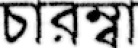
চারম্বা
